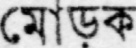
মোড়ক
